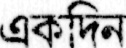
একদিন
